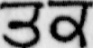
ਤਕ
